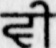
ਵੀ
